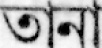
তানা
